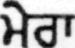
ਮੇਰਾ
